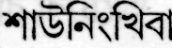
শাউনিংখিবা
